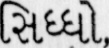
સિધ્ધો
